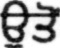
ਉਤੋਂ
